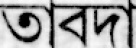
তাবদা
